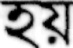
হয়
